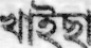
খাইছা
